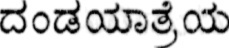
ದಂಡಯಾತ್ರೆಯ
